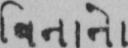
વિનાનો
